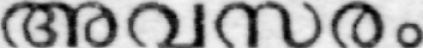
അവസരം
